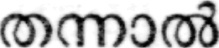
തന്നാല്‍
